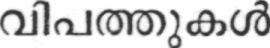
വിപത്തുകള്‍
